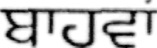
ਬਾਹਵਾਂ
